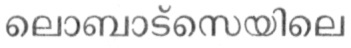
ലൊബാട്സെയിലെ
